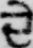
ਦੇ
